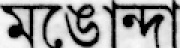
মঙোন্দা
